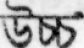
উচ্চ
